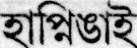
হাপ্নিঙাই
